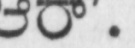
ಆರ್.
